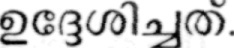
ഉദ്ദേശിച്ചത്.
